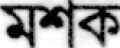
মশক
